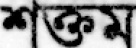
শক্তম
